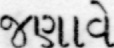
જણાવે
